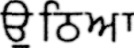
ਉਠਿਆ
